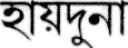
হায়দুনা
